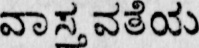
ವಾಸ್ತವತೆಯ
